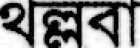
থল্লবা
